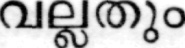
വല്ലതും
